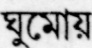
ঘুমোয়
